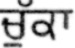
ਚੁੱਕਾ
